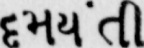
દમયંતી
